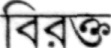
বিরক্ত
